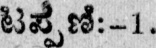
ಟಿಪ್ಪಣಿ:-1.
